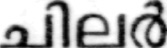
ചിലര്‍
